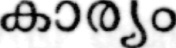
കാര്യം
